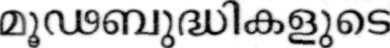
മൂഢബുദ്ധികളുടെ
